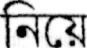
নিয়ে
